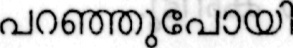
പറഞ്ഞുപോയി
